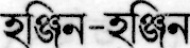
হঞ্জিন-হঞ্জিন
